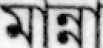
মান্না
